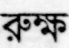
রুক্ষ
